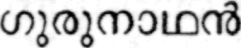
ഗുരുനാഥന്‍
